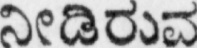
ನೀಡಿರುವ
